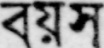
বয়স
